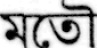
মতৌ
